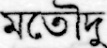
মতৌদু
